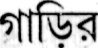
গাড়ির
